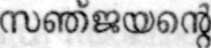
സഞ്ജയന്റെ
